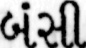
બંસી
